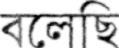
বলেছি
